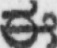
ಈ
